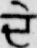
ਦੇ
